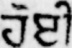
ਹੋਈ
